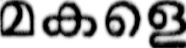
മകളെ
